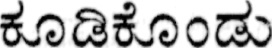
ಕೂಡಿಕೊಂಡು
